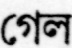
গেল
